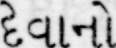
દેવાનો
